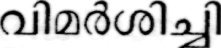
വിമര്‍ശിച്ചി
